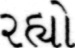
રહ્યો
